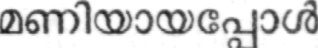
മണിയായപ്പോള്‍
